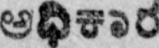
ಅಧಿಕಾರ
